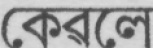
কেৱলে
